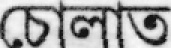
চোলাত
